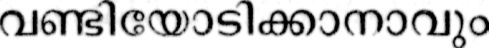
വണ്ടിയോടിക്കാനാവും
